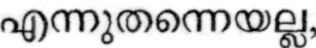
എന്നുതന്നെയല്ല,
